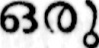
ഒരു
